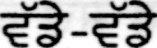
ਵੱਡੇ-ਵੱਡੇ
